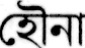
হৌনা
